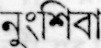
নুংশিবা
